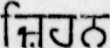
ਜ਼ਿਹਨ
